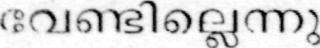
വേണ്ടില്ലെന്നു
